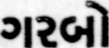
ગરબો
